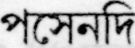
পসেনদি
